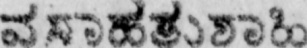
ವಸಾಹತುಶಾಹಿ
